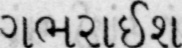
ગભરાઈશ
